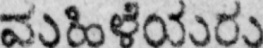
ಮಹಿಳೆಯರು
